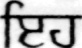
ਇਹ
